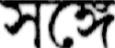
সঙ্গে
